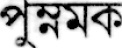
পুম্নমক
